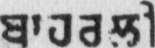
ਬਾਹਰਲੀ
